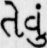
તેવું
